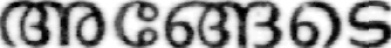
അങ്ങേടെ
